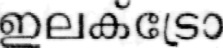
ഇലക്ട്രോ
